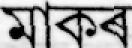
মাকৰ
